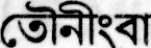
তৌনীংবা
